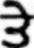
ਤੇ
